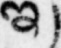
ಇ)
